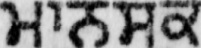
ਮਾਨਸਕ
